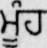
ਮੂੰਹ
